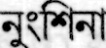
নুংশিনা
